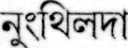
নুংথিলদা
